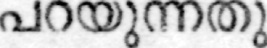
പറയുന്നതു
